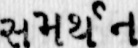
સમર્થન
